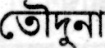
তৌদুনা
